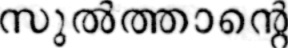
സുല്‍ത്താന്റെ
